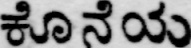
ಕೊನೆಯ
